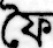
ফৈ
